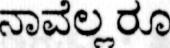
ನಾವೆಲ್ಲರೂ
